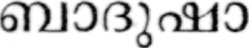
ബാദുഷാ
